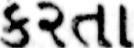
કરતા
